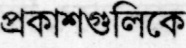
প্রকাশগুলিকে
